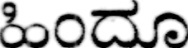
ಹಿಂದೂ
